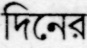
দিনের
